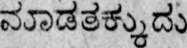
ಮಾಡತಕ್ಕುದು
